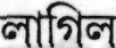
লাগিল
